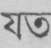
যত
